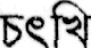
চৎখি
